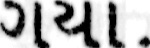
ગયા.
